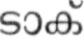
ടാക്
